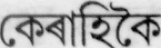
কেৰাহিকৈ
